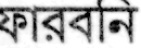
ফারবনি
